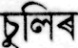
চুলিৰ
